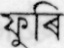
ফুৰি
